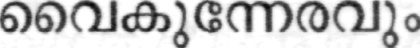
വൈകുന്നേരവും
